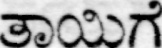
ತಾಯಿಗೆ
